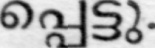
പ്പെട്ടു.
